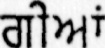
ਗੀਆਂ
